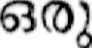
ഒരു
